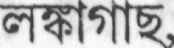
লঙ্কাগাছ,
